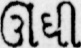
ઊંઘી
